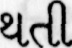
થતી
